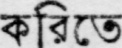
করিতে
